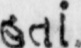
હતાં.
